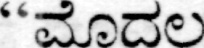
"ಮೊದಲ
